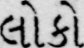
લોકો
